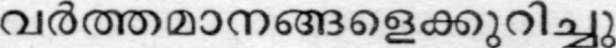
വര്‍ത്തമാനങ്ങളെക്കുറിച്ചു
